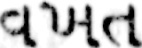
વખત
